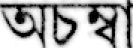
অচম্বা
